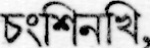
চংশিনখি,
